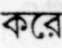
করে
